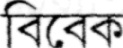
বিবেক
